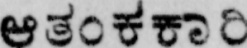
ಆತಂಕಕಾರಿ
